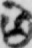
છે
